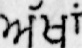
ਅੱਖਾਂ
